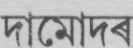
দামোদৰ
